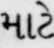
માટે
